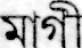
মাগী
